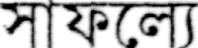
সাফল্যে
